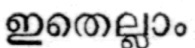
ഇതെല്ലാം
